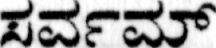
ಸರ್ವಮ್
